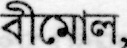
বীমোল,
